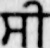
ਸੀ
